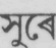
সুৰে
